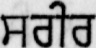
ਸਰੀਰ
